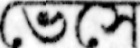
ভেসে
